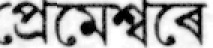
প্রেমেশ্বৰে
